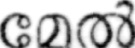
മേല്‍
